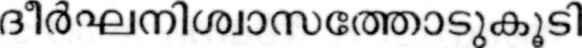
ദീര്‍ഘനിശ്വാസത്തോടുകൂടി
